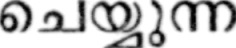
ചെയ്യുന്ന
